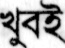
খুবই
